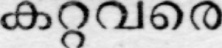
കറ്റവരെ
